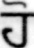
ਹੋ
